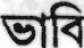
ভাবি
